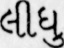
લીધુ
